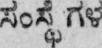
ಸಂಸ್ಥೆಗಳ
